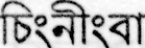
চিংনীংবা
